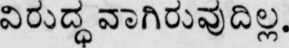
ವಿರುದ್ಧವಾಗಿರುವುದಿಲ್ಲ.
